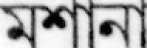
মশানা
